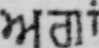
ਅਗਾਂ
